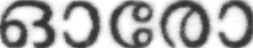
ഓരോ
